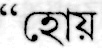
“হোয়
